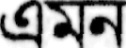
এমন
